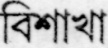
বিশাখা
